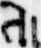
તો
